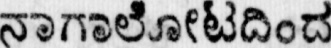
ನಾಗಾಲೋಟದಿಂದ
